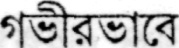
গভীরভাবে
